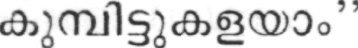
കുമ്പിട്ടുകളയാം”
